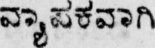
ವ್ಯಾಪಕವಾಗಿ
